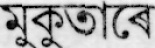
মুকুতাৰে
